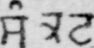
ਸੰਕਟ
